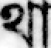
থা
